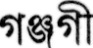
গঞ্জগী
